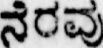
ನೆರವು
